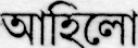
আহিলো
